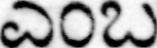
ಎಂಬ
